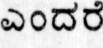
ಎಂದರೆ
